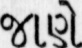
જાણે
